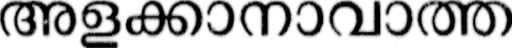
അളക്കാനാവാത്ത
